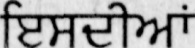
ਇਸਦੀਆਂ
